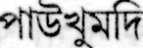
পাউখুমদি
